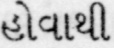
હોવાથી
